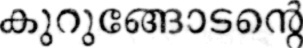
കുറുങ്ങോടന്റെ
